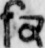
ਕਿ
